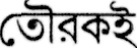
তৌরকই
